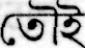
তৌই
